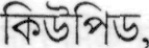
কিউপিড,
